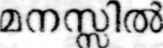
മനസ്സില്‍
